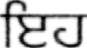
ਇਹ
